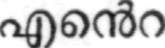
എന്റെ
